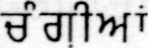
ਚੰਗੀਆਂ
